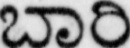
ಬಾರಿ
